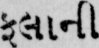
ફલાની
